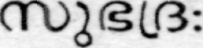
സുഭദ്ര:
